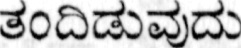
ತಂದಿಡುವುದು
